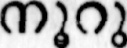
നൂറു
